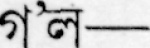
গ'ল-
